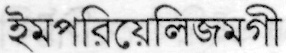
ইমপরিয়েলিজমগী
